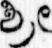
ಶ್ರೀ
